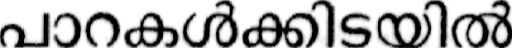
പാറകള്‍ക്കിടയില്‍
